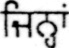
ਜਿਨ੍ਹਾਂ
